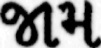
જામ
